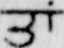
ਤਾਂ
